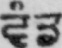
ਵੰਡ
